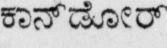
ಕಾನ್‌ಡೋರ್
